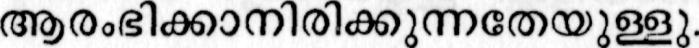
ആരംഭിക്കാനിരിക്കുന്നതേയുള്ളു.
